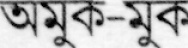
অমুক-মুক
